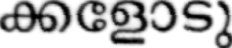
ക്കളോടു
